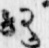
કરું
